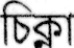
চিক্না
